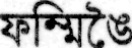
ফম্মিঙৈ
